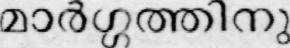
മാര്‍ഗ്ഗത്തിനു
